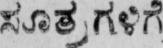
ಸೂತ್ರಗಳಿಗೆ
